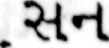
સન
